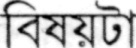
বিষয়টা
